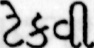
ટેકવી
